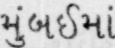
મુંબઈમાં
